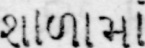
શાળામાં
